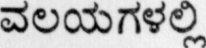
ವಲಯಗಳಲ್ಲಿ
